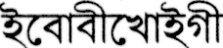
ইবোবীখোইগী
